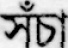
সঁচা
